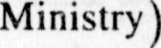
Ministry)
